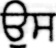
ਉਸ
